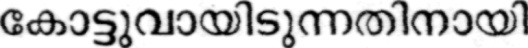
കോട്ടുവായിടുന്നതിനായി
